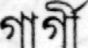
গার্গী
